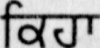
ਕਿਹਾ
